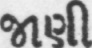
જાણી
